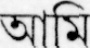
আমি
